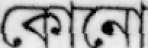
কোনো
